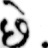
છે.
